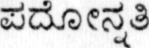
ಪದೋನ್ನತಿ
